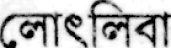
লোৎলিবা
